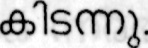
കിടന്നു.
